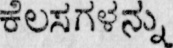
ಕೆಲಸಗಳನ್ನು
